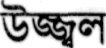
উজ্জ্বল
